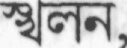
স্খলন,
